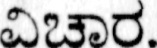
ವಿಚಾರ.
